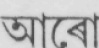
আৰো
